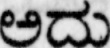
ಅದು
